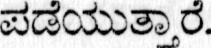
ಪಡೆಯುತ್ತಾರೆ.
